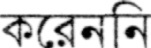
করেননি
